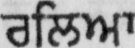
ਰਲਿਆ
